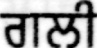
ਗਲੀ
